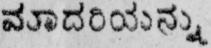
ಮಾದರಿಯನ್ನು
